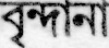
বৃন্দানা
